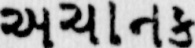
અચાનક
